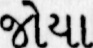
જોયા
